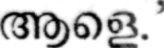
ആളെ.’
